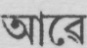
আৱে
